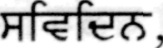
ਸਵਿਦਨ,
